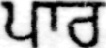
ਪਾਰ
